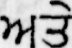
ਅਤੇ
